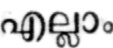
എല്ലാം
